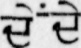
ਦੇਂਦੇ
